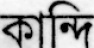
কান্দি
